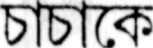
চাচাকে
